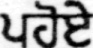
ਪਹੋਏ
